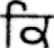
ਕਿ
